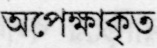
অপেক্ষাকৃত
